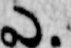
ಎ.
